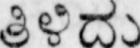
ತಿಳಿದು
